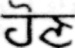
ਹੋਣ
